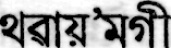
থৱায়’মগী
